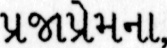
પ્રજાપ્રેમના,
